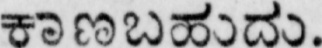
ಕಾಣಬಹುದು.
